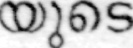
യുടെ
